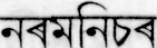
নৰমনিচৰ
